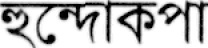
হুন্দোকপা
